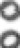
ঃ
